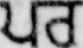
ਪਰ
